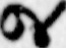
જ
